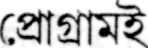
প্রোগ্রামই
